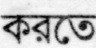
করতে
